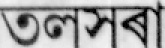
তলসৰা
